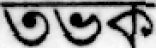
তভক
